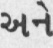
અને
